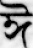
ঈ
